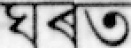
ঘৰত
